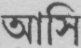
আসি
